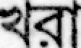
খরা
